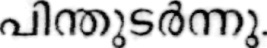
പിന്തുടര്‍ന്നു.
